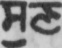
ਸੁਣ
